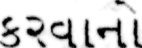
કરવાનો
